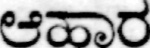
ಆಹಾರ
